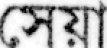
সেয়া
